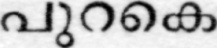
പുറകെ
